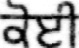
ਕੋਈ
